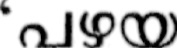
‘പഴയ
